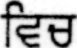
ਵਿਚ
